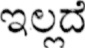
ಇಲ್ಲದೆ
